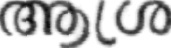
ആശ്ര
